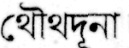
থৌথদূনা
